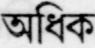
অধিক
